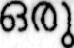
ഒരു
